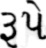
રૂપે
